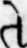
તે
